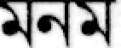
মনম
